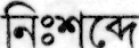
নিঃশব্দে
